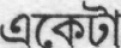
একেটা
